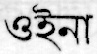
ওইনা
